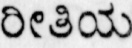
ರೀತಿಯ
